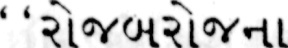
"રોજબરોજના
